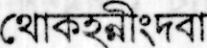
থোকহন্নীদবা
